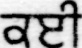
ਕਈ
